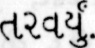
તરવર્યું.
